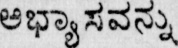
ಅಭ್ಯಾಸವನ್ನು
